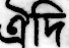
ঐদি
